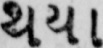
થયા
